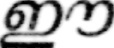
ഈ
